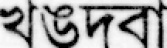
খঙদবা
